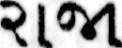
રાજા
